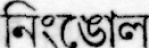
নিংঙোল
